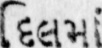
દિલમાં
